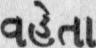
વહેતા
